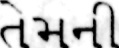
તેમની
